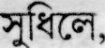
সুধিলে,
